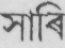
সাৰি
